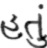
હતું
